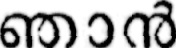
ഞാന്‍
